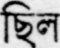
ছিল
